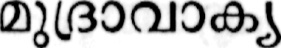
മുദ്രാവാക്യ
